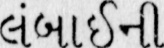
લંબાઈની
